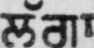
ਲੱਗਾ
